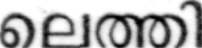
ലെത്തി
